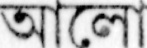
আলো
